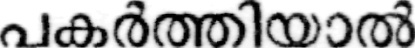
പകര്‍ത്തിയാല്‍
